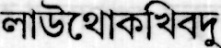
লাউথোকখিবদু
